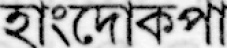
হাংদোকপা
